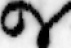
જ
